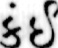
કંઈ
